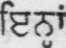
ਇਨ੍ਹਾਂ
